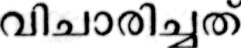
വിചാരിച്ചത്
